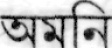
অমনি
